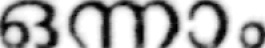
ഒന്നാം
